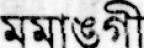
মমাঙগী
